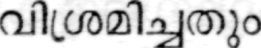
വിശ്രമിച്ചതും
